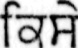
ਕਿਸੇ
